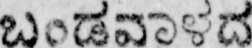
ಬಂಡವಾಳದ
